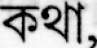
কথা,
